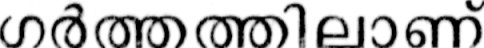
ഗര്‍ത്തത്തിലാണ്
